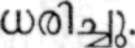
ധരിച്ചു.
